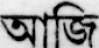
আজি
